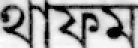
থাফম
